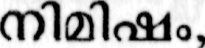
നിമിഷം,
